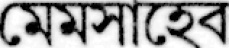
মেমসাহেব
